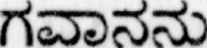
ಗವಾನನು
